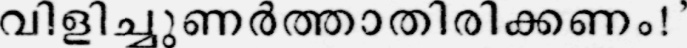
വിളിച്ചുണര്‍ത്താതിരിക്കണം!'
